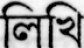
লিখি
